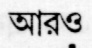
আরও
